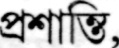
প্রশান্তি,
